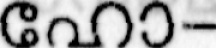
ഹോ-
